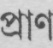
প্ৰাণ
